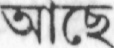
আছে
